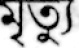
মৃত্যু
